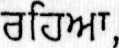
ਰਹਿਆ,
